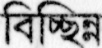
বিচ্ছিন্ন
